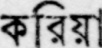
করিয়া
